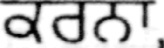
ਕਰਨਾ,
